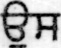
ਉਸ
